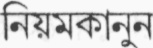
নিয়মকানুন
